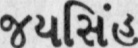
જયસિંહ
